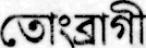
তোংব্রাগী
